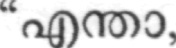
“എന്താ,
